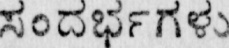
ಸಂದರ್ಭಗಳು
